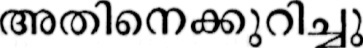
അതിനെക്കുറിച്ചു
